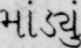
માંડ્યું
